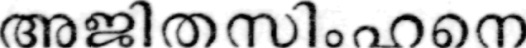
അജിതസിംഹനെ
